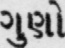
ગુણો
